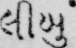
લીબું
